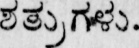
ಶತ್ರುಗಳು.
